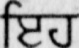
ਇਹ
